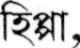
হিপ্পা,
